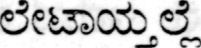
ಲೇಟಾಯ್ತಲ್ಲೆ
